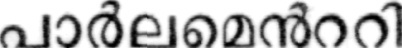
പാര്‍ലമെൻററി
